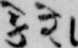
કેરો
